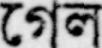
গেল
